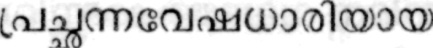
പ്രച്ഛന്നവേഷധാരിയായ
